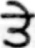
ਤੇ
